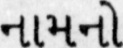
નામનો
